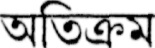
অতিক্রম
